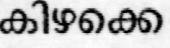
കിഴക്കെ
